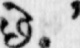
છે.'
